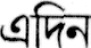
এদিন
